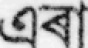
এৰা
